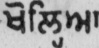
ਖੋਲ੍ਹਿਆ
